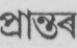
প্ৰান্তৰ
